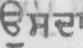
ਉਸਦਾ
